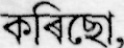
কৰিছো,
